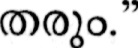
തരും.”
